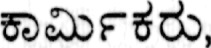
ಕಾರ್ಮಿಕರು,
